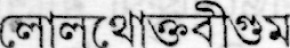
লোনথোক্তবীগুম
